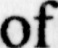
of
